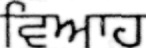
ਵਿਆਹ
